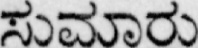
ಸುಮಾರು
